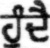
ਹੁੰਦੈ
